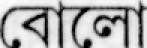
বোলো
